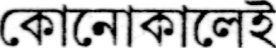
কোনোকালেই
